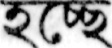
হচ্ছে
